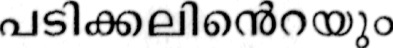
പടിക്കലിന്റെയും
